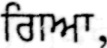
ਗਿਆ,
